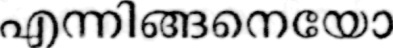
എന്നിങ്ങനെയോ
